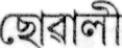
ছোৱালী
